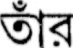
তাঁর
